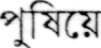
পুষিয়ে
